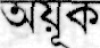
অয়ূক
